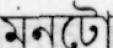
মনটো
